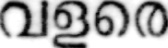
വളരെ
